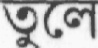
তুলে
